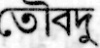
তৌবদু
